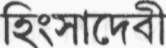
হিংসাদেবী
